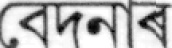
বেদনাৰ
